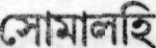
সোমালহি
